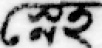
স্নেহ
